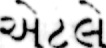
એટલે
